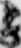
કે
